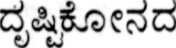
ದೃಷ್ಟಿಕೋನದ
